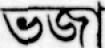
ভজা
